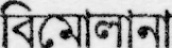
বিমোলানা
